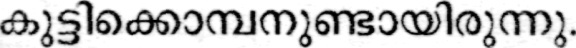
കുട്ടിക്കൊമ്പനുണ്ടായിരുന്നു.
